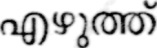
എഴുത്ത്
